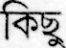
কিছু
